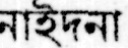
নাইইদনা
